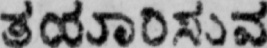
ತಯಾರಿಸುವ
